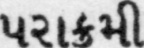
પરાક્રમી
